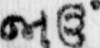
જાઉં
